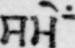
ਸਮੇਂ
